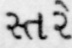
સ્તરે
